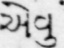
એવું
